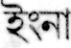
ইংনা
